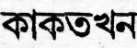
কাকতখন
